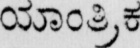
ಯಾಂತ್ರಿಕ
